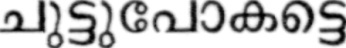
ചുട്ടുപോകട്ടെ
